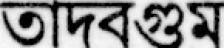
তাদবগুম
